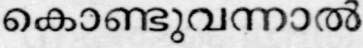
കൊണ്ടുവന്നാല്‍
